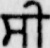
ਸੀ
